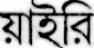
য়াইরি
